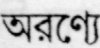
অরণ্যে
